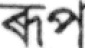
ৰূপ
